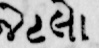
જેટલો
